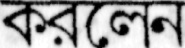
করলেন
